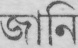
জানি
